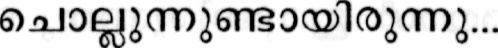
ചൊല്ലുന്നുണ്ടായിരുന്നു....
